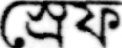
স্রেফ
